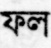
ফল
